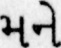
મને
